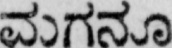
ಮಗನೂ
